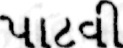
પાટવી
